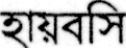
হায়বসি
